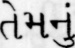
તેમનું
